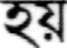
হয়
